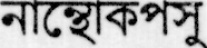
নান্থোকপসু
